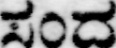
ಸಂದ
